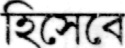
হিসেবে
